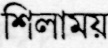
শিলাময়
